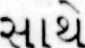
સાથે
